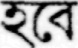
হবে
